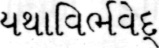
યથાવિર્ભવેદ્
